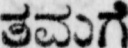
ತಮಗೆ
